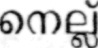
നെല്ല്
